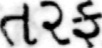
તરફ
